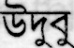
উদুবু
